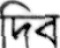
দিব
